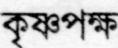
কৃষ্ণপক্ষ
